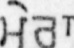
ਮੇਰਾ
